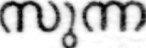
സുന്ന
